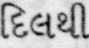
દિલથી
